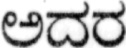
ಅದರ
